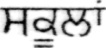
ਸਕੂਲਾਂ
